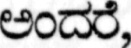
ಅಂದರೆ,
